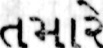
તમારે
